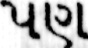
પણ
